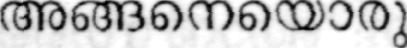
അങ്ങനെയൊരു
